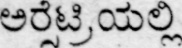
ಅರ್‍ಸೆಟ್ರಿಯಲ್ಲಿ
